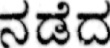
ನಡೆದ
